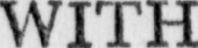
WITH
